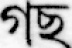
গছ
